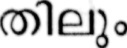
തിലും
